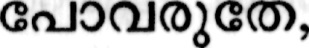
പോവരുതേ,
